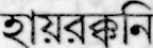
হায়রক্কনি
